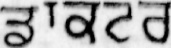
ਡਾਕਟਰ
